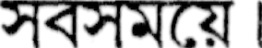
সবসময়ে।
